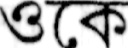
ওকে
